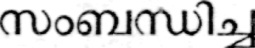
സംബന്ധിച്ച
